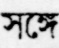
সঙ্গে
